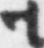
ન
